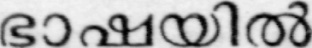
ഭാഷയില്‍
